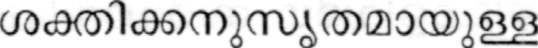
ശക്തിക്കനുസൃതമായുള്ള
